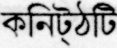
কনিট্ঠটি
